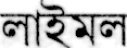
লাইমল
